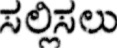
ಸಲ್ಲಿಸಲು
